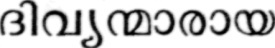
ദിവ്യന്മാരായ
